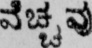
ವೆಚ್ಚವು
